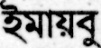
ইমায়বু
